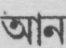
আন
